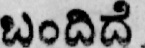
ಬಂದಿದೆ.
